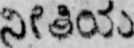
ನೀತಿಯ
